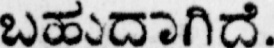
ಬಹುದಾಗಿದೆ.
